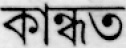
কান্ধত
